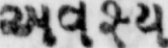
અવશ્ય
